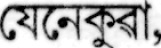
যেনেকুৱা,
